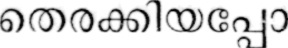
തെരക്കിയപ്പോ
